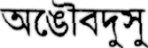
অঙৌবদুসু
